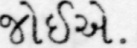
જોઈએ.
